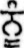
ਨੂੰ
